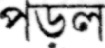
পড়ল
